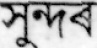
সুন্দৰ
